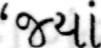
'જ્યાં
